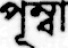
পূম্বা
